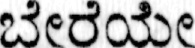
ಬೇರೆಯೇ
